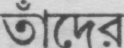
তাঁদের
